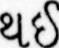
થઈ
